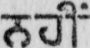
ਨਹੀਂ
